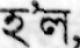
হ'ল,
